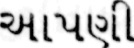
આપણી
